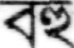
বহু
